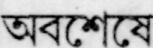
অবশেষে
